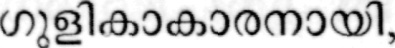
ഗുളികാകാരനായി,
